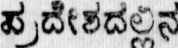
ಪ್ರದೇಶದಲ್ಲಿನ
